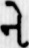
ને
